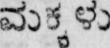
ಮಕ್ಕಳು
